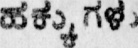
ಹಕ್ಕುಗಳು
